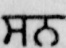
ਸਨ
